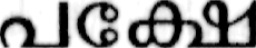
പക്ഷേ
